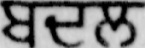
ਬਦਲ
